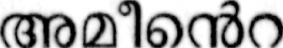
അമീന്റെ
